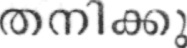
തനിക്കു
